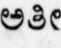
ಅತೀ
